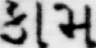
કામ
